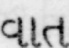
વાત
